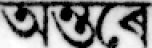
অন্তৰে
